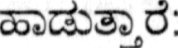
ಹಾಡುತ್ತಾರೆ:
